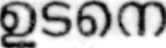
ഉടനെ
